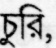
চুরি,
